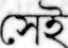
সেই
